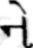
ને
